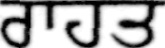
ਰਾਹਤ
